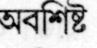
অবশিষ্ট
